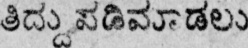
ತಿದ್ದುಪಡಿಮಾಡಲು
